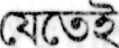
যেতেই
